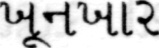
ખૂનખાર
